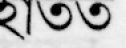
হাতত
